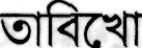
তাবিখো
